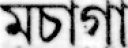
মচাগা
